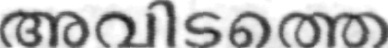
അവിടത്തെ
